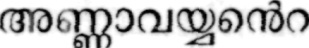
അണ്ണാവയ്യന്റെ
